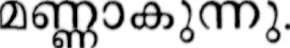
മണ്ണാകുന്നു.
